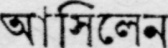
আসিলেন
